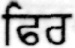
ਫਿਰ
